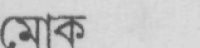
মোক
